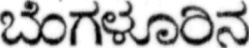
ಬೆಂಗಳೂರಿನ
